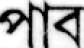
পাব
